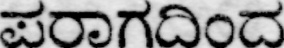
ಪರಾಗದಿಂದ
